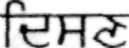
ਦਿਸਣ
